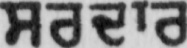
ਸਰਦਾਰ
